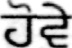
ਹੋਵੇ
